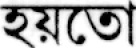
হয়তো
